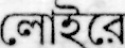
লোইরে
